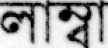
লাম্বা
